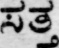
ಸತ್ತ
